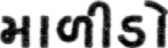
માળીડો
